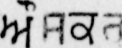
ਔਸਕਰ
